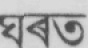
ঘৰত
